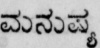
ಮನುಷ್ಯ
